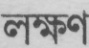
লক্ষণ
